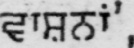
ਵਾਸ਼ਨਾਂ',
